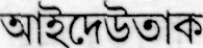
আইদেউতাক
